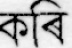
কৰি
